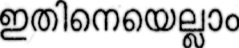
ഇതിനെയെല്ലാം
